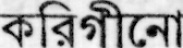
করিগীনো
